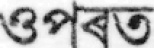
ওপৰত
